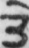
ਤੇ
